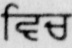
ਵਿਚ
